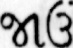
જાઉં
